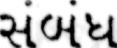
સંબંધ
